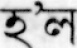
হ'ল
